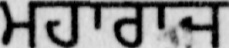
ਮਹਾਰਾਜ
